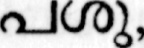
പശു,
